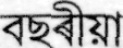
বছৰীয়া
